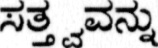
ಸತ್ತ್ವವನ್ನು
